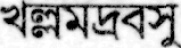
খল্লমদ্রবসু
